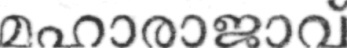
മഹാരാജാവ്
